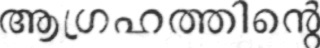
ആഗ്രഹത്തിന്റെ
